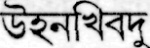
উহনখিবদু
